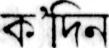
ক'দিন
